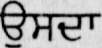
ਉਸਦਾ
